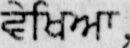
ਵੇਖਿਆ,
